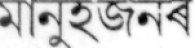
মানুহজনৰ
